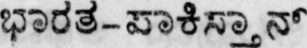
ಭಾರತ-ಪಾಕಿಸ್ತಾನ್
